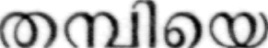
തമ്പിയെ
